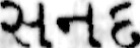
સનદ
